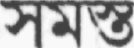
সমস্ত
